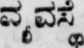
ವ್ಯವಸ್ಥೆ
